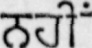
ਨਹੀਂ
